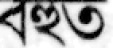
বহুত
